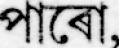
পাৰো,
